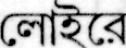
লোইরে
